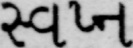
સ્વપ્ન
